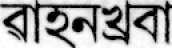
ৱাহনখ্রবা
